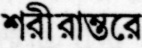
শরীরান্তরে
